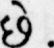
છે.
